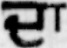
ਦਾ
